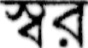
স্বর
